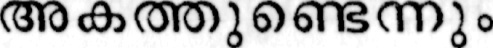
അകത്തുണ്ടെന്നും
